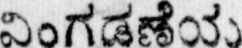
ವಿಂಗಡಣೆಯ
